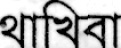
থাখিবা
